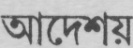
আদেশয়
